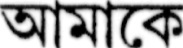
আমাকে
